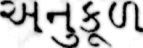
અનુકૂળ
